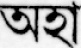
অহা
